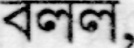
বলল,
